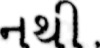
નથી.
